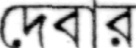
দেবার
